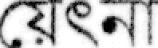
য়েৎনা
